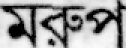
মরুপ
